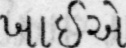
ખાઈએ
